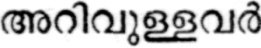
അറിവുള്ളവര്‍
